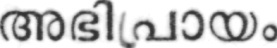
അഭിപ്രായം
